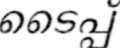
ടൈപ്പ്
